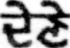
ਦੇਣੇ
